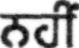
ਨਹੀਂ
